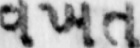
વખત
